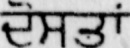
ਦੋਸਤਾਂ
